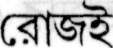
রোজই
